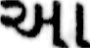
આ
